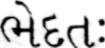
ભેદતઃ
